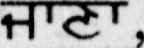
ਜਾਣਾ,
